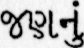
જણનું
